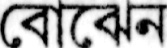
বোঝেন
